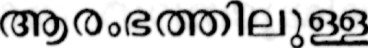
ആരംഭത്തിലുള്ള
